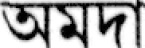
অমদা
